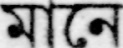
মানে
